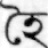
হৈ
